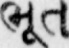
ભૂત
